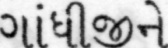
ગાંધીજીને
